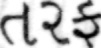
તરફ
